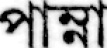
পাম্না
